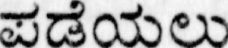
ಪಡೆಯಲು
